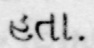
હતા.
